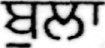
ਬੁਲਾ
